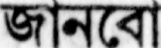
জানবো
